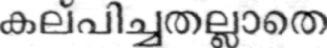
കല്പിച്ചതല്ലാതെ
